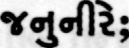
જનુનીરે;
